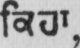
ਕਿਹਾ,
